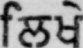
ਲਿਖੇ
